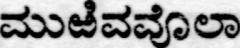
ಮುಱವವೊಲಾ
